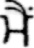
ਮੈਂ
